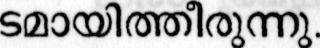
ടമായിത്തീരുന്നു.
